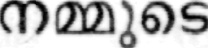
നമ്മുടെ
